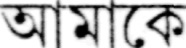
আমাকে
